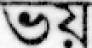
ভয়
